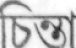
চিন্তা
